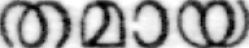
തമായ
